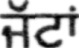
ਜੱਟਾਂ
